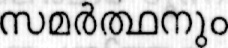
സമര്‍ത്ഥനും
